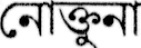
নোক্তুনা
